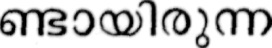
ണ്ടായിരുന്ന
